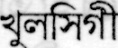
খুলসিগী
